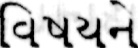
વિષયને
